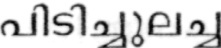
പിടിച്ചുലച്ച
